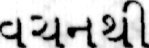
વચનથી
